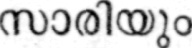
സാരിയും
